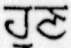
ਹੁਣ
